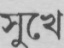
সুখে
